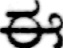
ಈ
